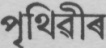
পৃথিৱীৰ
